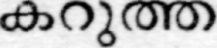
കറുത്ത
